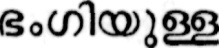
ഭംഗിയുള്ള
